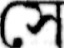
সে
